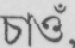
চাওঁ,
